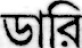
ডারি
